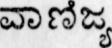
ವಾಣಿಜ್ಯ
